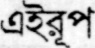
এইরূপ
